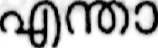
എന്താ
